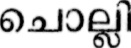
ചൊല്ലി
